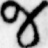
જ
